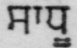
ਸਾਧੂ
